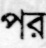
পর
